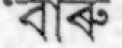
'বাৰু
